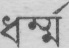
ধৰ্ম্ম
